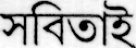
সবিতাই
